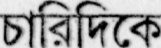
চারিদিকে
